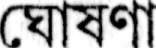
ঘোষণা
